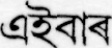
এইবাৰ
